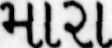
મારા
